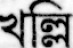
খল্লি
